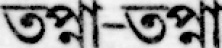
তপ্না-তপ্না
